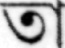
তা
